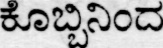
ಕೊಬ್ಬಿನಿಂದ
